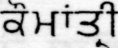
ਕੌਮਾਂਤ੍ਰੀ
